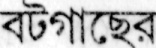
বটগাছের
